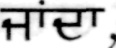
ਜਾਂਦਾ,
